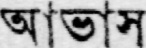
আভাস
